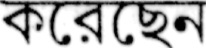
করেছেন
